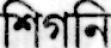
শিগনি
